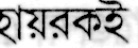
হায়রকই
